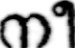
നീ
